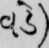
વડે)
